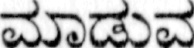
ಮಾಡುವ
